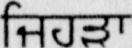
ਜਿਹੜਾ
